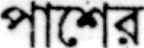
পাশের
